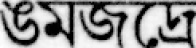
ঙমজদ্রে
